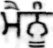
ਮੈਨੂੰ
